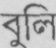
বুলি
